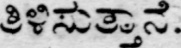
ತಿಳಿಸುತ್ತಾನೆ.
